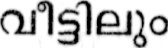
വീട്ടിലും
